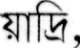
য়াদ্রি,
